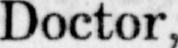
Doctor,
